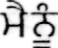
ਮੈਨੂੰ
